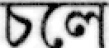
চলে
